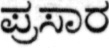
ಪ್ರಸಾರ
